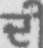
ਦੀ
